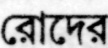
রোদের
